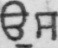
ਉਸ
